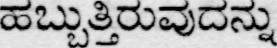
ಹಬ್ಬುತ್ತಿರುವುದನ್ನು
